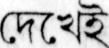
দেখেই
